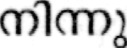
നിന്നു
